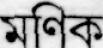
মণিক
